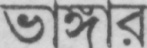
ভাঙ্গার
